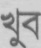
খুব
